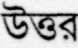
উত্তর
